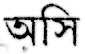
অসি
